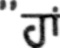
''ਹਾਂ
